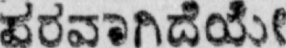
ಪರವಾಗಿದೆಯೇ
